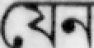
যেন
